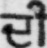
ਦੀ
